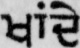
ਖਾਂਦੇ
